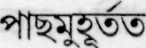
পাছমুহূর্তত
